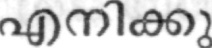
എനിക്കു
